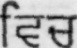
ਵਿਚ
